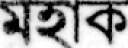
মহাক
